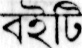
বইটি
